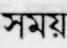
সময়
